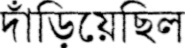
দাঁড়িয়েছিল
